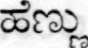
ಹೆಣ್ಣು
